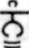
ਨੂੰ
